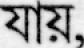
যায়,
